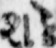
શકે
